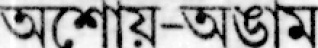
অশোয়-অঙাম
